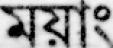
ময়াং
